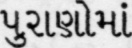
પુરાણોમાં
